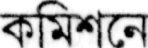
কমিশনে
